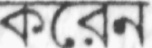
করেন
